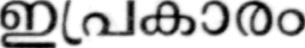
ഇപ്രകാരം
